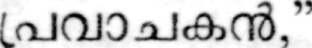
പ്രവാചകന്‍,”
